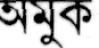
অমুক
